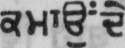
ਕਮਾਉਂਦੇ
